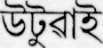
উটুৱাই
